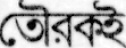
তৌরকই
